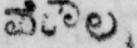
ಮೌಲ್ಯ
